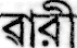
ৱারী
